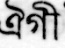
ঐগী
